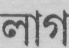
লাগ
